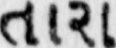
તારા
